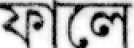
ফালে
